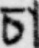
চা
